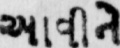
આવીને
